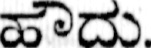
ಹೌದು.
